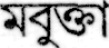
মবুক্তা
